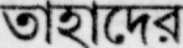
তাহাদের
